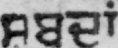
ਸ਼ਬਦਾਂ
